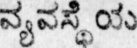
ವ್ಯವಸ್ಥೆಯ
